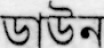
ডাউন
